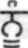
ਨੂੰ
